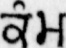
ਕੰਮ
